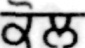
ਕੋਲ
